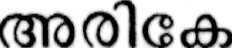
അരികേ
